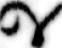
જ
